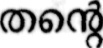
തന്റെ
